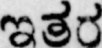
ಇತರ
